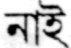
নাই
